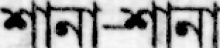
শানা-শানা
